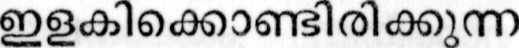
ഇളകിക്കൊണ്ടിരിക്കുന്ന
